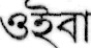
ওইবা
